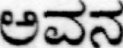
ಅವನ
